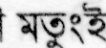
মতুংই
